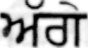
ਅੱਗੇ
